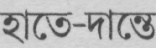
হাতে-দান্তে
